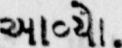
આવ્યો.
